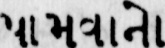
પામવાનો
